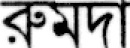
রুমদা
